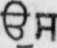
ਉਸ
